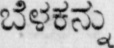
ಬೆಳಕನ್ನು
